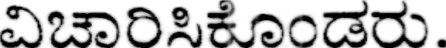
ವಿಚಾರಿಸಿಕೊಂಡರು.
